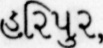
હરિપુર,
